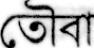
তৌবা
